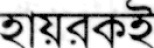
হায়রকই
